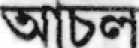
আচল
